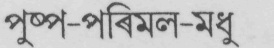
পুষ্প-পৰিমল-মধু
